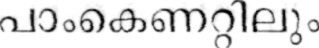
പാംകെണറ്റിലും
